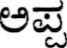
ಅಪ್ಪ
